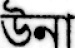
উনা
